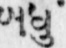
બધું
